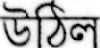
উঠিল
